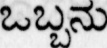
ಒಬ್ಬನು
